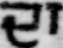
ਦਾ
